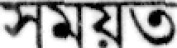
সময়ত
